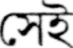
সেই
